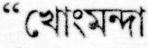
“খোংমন্দা
